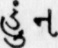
હુંન
